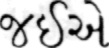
જઈએ
